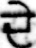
ਦੇ
